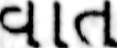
વાત
